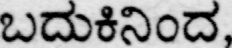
ಬದುಕಿನಿಂದ,
